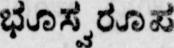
ಭೂಸ್ವರೂಪ
